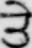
ਤੇ
